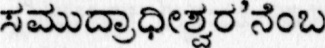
ಸಮುದ್ರಾಧೀಶ್ವರ’ನೆಂಬ
